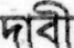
দাবী
